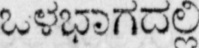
ಒಳಭಾಗದಲ್ಲಿ
